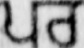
ਪਰ
